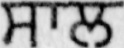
ਸਾਲ
